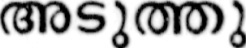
അടുത്തു
